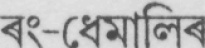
ৰং-ধেমালিৰ
